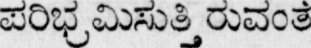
ಪರಿಭ್ರಮಿಸುತ್ತಿರುವಂತೆ
